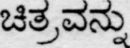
ಚಿತ್ರವನ್ನು
